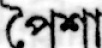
পৈশা
